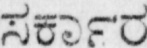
ಸರ್ಕಾರ
